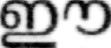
ഈ
